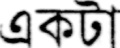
একটা
